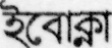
ইবোক্না
